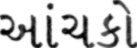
આંચકો
